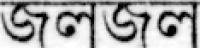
জলজল
